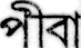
পীবা
